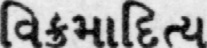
વિક્રમાદિત્ય
